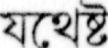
যথেষ্ট
